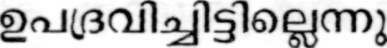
ഉപദ്രവിച്ചിട്ടില്ലെന്നു
